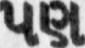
પણ
